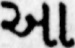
આ
